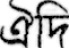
ঐদি
